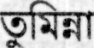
তুমিন্না
